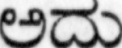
ಅದು
